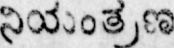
ನಿಯಂತ್ರಣ
